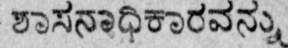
ಶಾಸನಾಧಿಕಾರವನ್ನು
